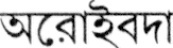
অরোইবদা
